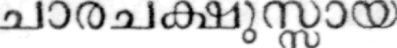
ചാരചക്ഷുസ്സായ
